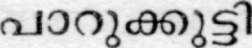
പാറുക്കുട്ടി
